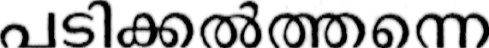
പടിക്കല്‍ത്തന്നെ
